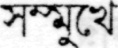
সম্মুখে
